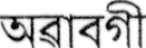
অৱাবগী
